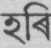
হৰি
